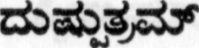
ದುಷ್ಟುತ್ರಮ್
